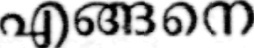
എങ്ങനെ
